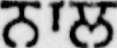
ਨਾਲ
